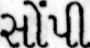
સોંપી
